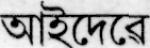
আইদেৱে
